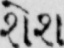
શેશ
